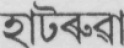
হাটৰুৱা
